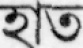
হাত
